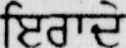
ਇਰਾਦੇ
